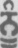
ਨੂੰ
